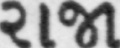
રાજા
